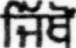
ਜਿੱਥੋਂ
